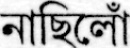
নাছিলোঁ
